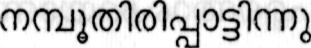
നമ്പൂതിരിപ്പാട്ടിന്നു
